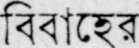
বিবাহের
